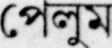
পেলুম
